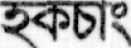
হকচাং
